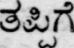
ತಪ್ಪಿಗೆ
